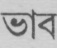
ভাব
